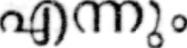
എന്നും
